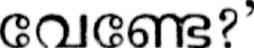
വേണ്ടേ?’
